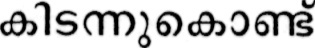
കിടന്നുകൊണ്ട്
